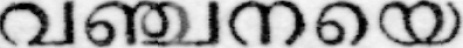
വഞ്ചനയെ
